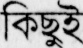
কিছুই
